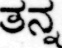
ತನ್ನ
